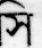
সি
